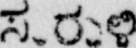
ಸುರುಳಿ
